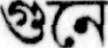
গুনে
